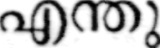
എന്തു
